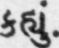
કહ્યું.
